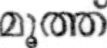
മൂത്ത്
